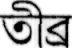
তীব্র
